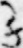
કે
